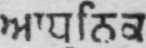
ਆਧੁਨਿਕ
